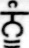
ਨੂੰ
